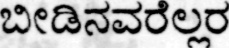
ಬೀಡಿನವರೆಲ್ಲರ
